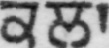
ਕਲਾ
